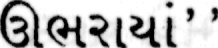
ઊભરાયાં"
